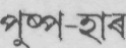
পুষ্প-হাৰ,
